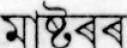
মাষ্টৰৰ
